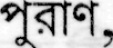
পুরাণ,
